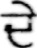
ਦੇ
